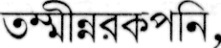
তম্মীন্নরকপনি,
